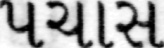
પચાસ
